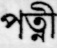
পত্নী
